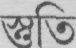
স্তুতি
